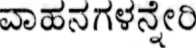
ವಾಹನಗಳನ್ನೇರಿ
